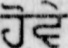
ਹੋਵੇ
